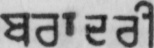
ਬਰਾਦਰੀ
